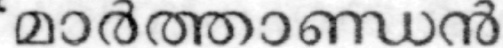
‘മാര്‍ത്താണ്ഡന്‍
